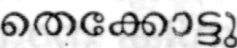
തെക്കോട്ടു
